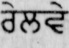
ਰੇਲਵੇ
